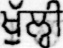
ਖੁੱਲ੍ਹੀ
